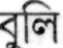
বুলি
